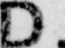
D.
